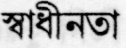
স্বাধীনতা
